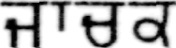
ਜਾਚਕ
